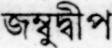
জম্বুদ্বীপ
